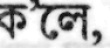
ক'লে,
